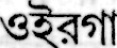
ওইরগা
